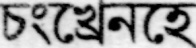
চংখ্রেনহে
